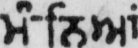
ਮੰਨਿਆਂ
